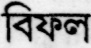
বিফল
